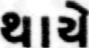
થાયે
